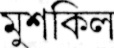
মুশকিল
